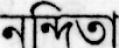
নন্দিতা
